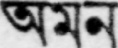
অমন
